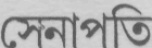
সেনাপতি
